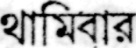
থামিবার
